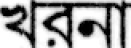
খরনা
